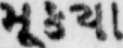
મૂક્યા
